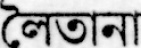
লৈতানা
